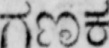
ಗಣಕ
